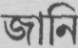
জানি
